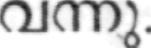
വന്നു.
